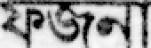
ফজনা
